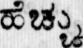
ಹೆಚ್ಚು
